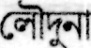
লৌদুনা
